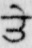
ਤੇ
